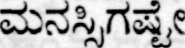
ಮನಸ್ಸಿಗಷ್ಟೇ
